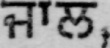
ਜਾਲ,
